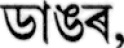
ডাঙৰ,
